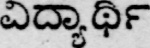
ವಿದ್ಯಾರ್ಥಿ
